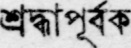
শ্রদ্ধাপূর্বক
